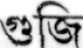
গুজি
